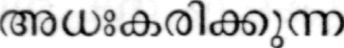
അധഃകരിക്കുന്ന
